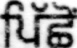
ਪਿੱਛੋਂ
